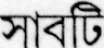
সাবটি
